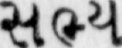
સભ્ય
